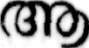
ആ
